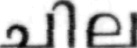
ചില
